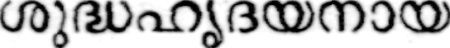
ശുദ്ധഹൃദയനായ
